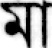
মা
